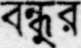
বন্ধুর
